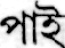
পাই
